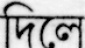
দিলে
